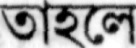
তাহলে
